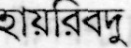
হায়রিবদু
